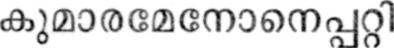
കുമാരമേനോനെപ്പറ്റി
